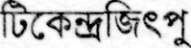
টিকেন্দ্রজিৎপু
